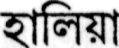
হালিয়া
